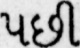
પછી
